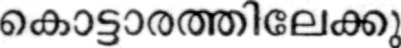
കൊട്ടാരത്തിലേക്കു
